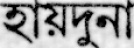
হায়দুনা
